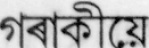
গৰাকীয়ে
